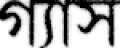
গ্যাস
